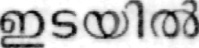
ഇടയില്‍
